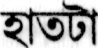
হাতটা
